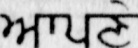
ਆਪਣੇ
